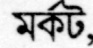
মর্কট,
